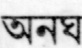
অনঘ
